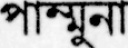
পাম্মুনা
